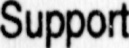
Support
